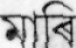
মাৰি
